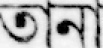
তানা
